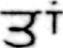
ਤਾਂ
